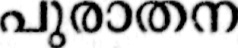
പുരാതന
